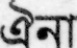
ঐনা
